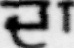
ਦਾ
